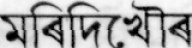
মৰিদিখৌৰ
